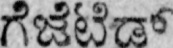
ಗೆಜೆಟೆಡ್
